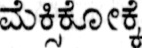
ಮೆಕ್ಸಿಕೋಕ್ಕೆ
